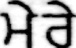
ਮੇਰੇ
